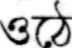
ওঠে
